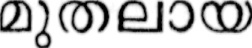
മുതലായ
